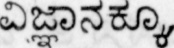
ವಿಜ್ಞಾನಕ್ಕೂ,
